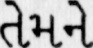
તેમને
